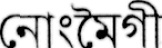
নোংমৈগী
